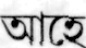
আহে
